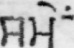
ਸਮੇਂ
